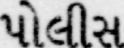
પોલીસ
